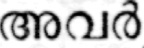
അവര്‍
